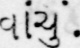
વાંચું.
